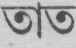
তাত
